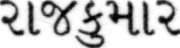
રાજકુમાર
